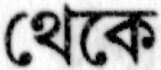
থেকে
